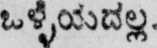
ಒಳ್ಳೆಯದಲ್ಲ.
